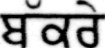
ਬੱਕਰੇ
